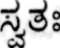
ಸ್ವತಃ
